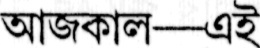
আজকাল-এই
